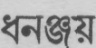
ধনঞ্জয়
